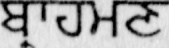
ਬ੍ਰਾਹਮਣ
